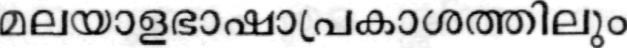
മലയാളഭാഷാപ്രകാശത്തിലും
